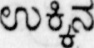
ಉಕ್ಕಿನ
